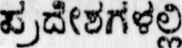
ಪ್ರದೇಶಗಳಲ್ಲಿ
